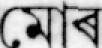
মোৰ
